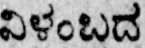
ವಿಳಂಬದ
